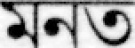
মনত
